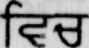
ਵਿਚ
